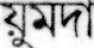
য়ুমদা
